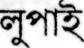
লুপাই
